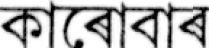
কাৰোবাৰ
